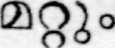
മറ്റും
